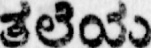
ತಲೆಯ
